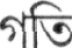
গতি
